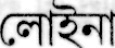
লোইনা
